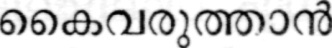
കൈവരുത്താന്‍
